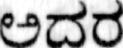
ಅದರ
